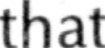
that
